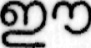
ഈ
